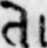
તો
